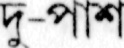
দু-পাশ
